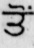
ਤੋਂ
